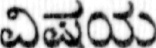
ವಿಷಯ
